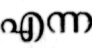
എന്ന
